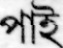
পাই
